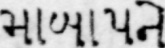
માબાપને
